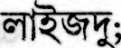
লাইজদু;
